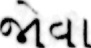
જોવા
